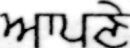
ਆਪਣੇ
